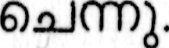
ചെന്നു.
